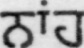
ਨਾਂਹ
